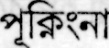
পূক্নিংনা
